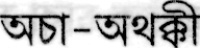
অচা-অথক্কী
